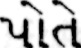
પોતે
